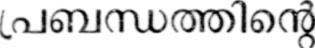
പ്രബന്ധത്തിന്റെ
